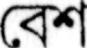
বেশ
